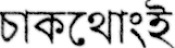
চাকথোংই
